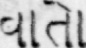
વાતો
